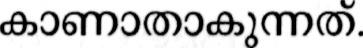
കാണാതാകുന്നത്.
